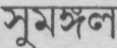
সুমঙ্গল
